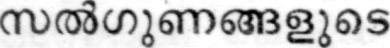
സല്‍ഗുണങ്ങളുടെ
